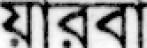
য়ারবা
